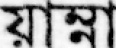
য়াম্না
